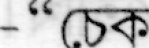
-“চেক
